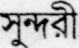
সুন্দরী
